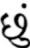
છું
